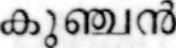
കുഞ്ചന്‍
